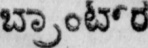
ಬ್ರಾಂಟ್‌ರ
